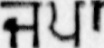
ਜਪਾ
